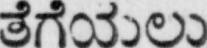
ತೆಗೆಯಲು
